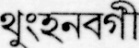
থুংহনবগী
